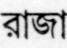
রাজা
